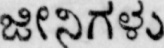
ಜೀನಿಗಳು
